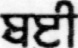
ਬਈ
